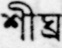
শীঘ্র
